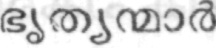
ഭൃത്യന്മാര്‍
